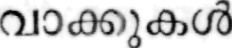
വാക്കുകള്‍
